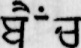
ਬੈਂਚ
